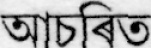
আচৰিত
